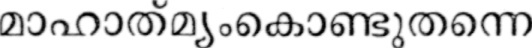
മാഹാത്മ്യംകൊണ്ടുതന്നെ
